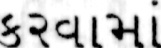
કરવામાં
